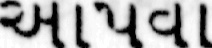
આપવા
